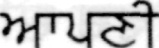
ਆਪਣੀ
